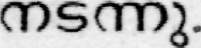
നടന്നു.
